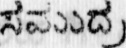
ಸಮುದ್ರ
